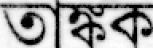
তাঙ্কক
